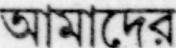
আমাদের
